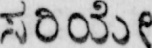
ಸರಿಯೇ
